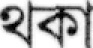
থকা
